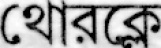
থোরক্লে
